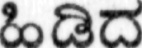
ಹಿಡಿದ
